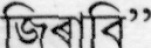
জিৰাবি"
